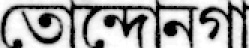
তোন্দোনগা
